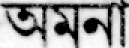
অমনা
